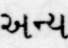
અન્ય
